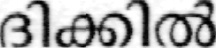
ദിക്കില്‍
